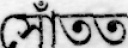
সোঁতত
